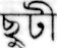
ছুটী
